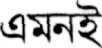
এমনই
